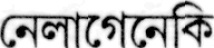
নেলাগেনেকি
